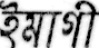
ইমাগী
